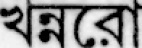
খন্নরো
